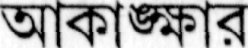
আকাঙ্ক্ষার
